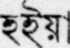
হইয়া
